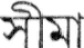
সীমা
